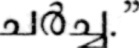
ചര്‍ച്ച."
